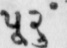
પૂરું
